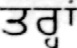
ਤਰ੍ਹਾਂ
